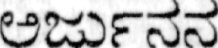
ಅರ್ಜುನನ
